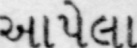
આપેલા
